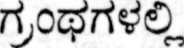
ಗ್ರಂಥಗಳಲ್ಲಿ
